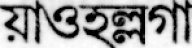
য়াওহল্লগা
